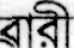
ৱারী
